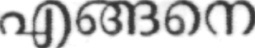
എങ്ങനെ
